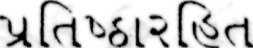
પ્રતિષ્ઠારહિત
